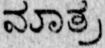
ಮಾತ್ರ
